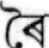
ৰৈ
